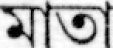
মাতা
